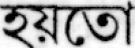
হয়তো
